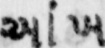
આંખ
